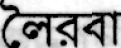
লৈরবা
